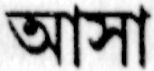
আসা
